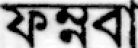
ফম্নবা
